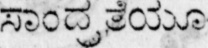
ಸಾಂದ್ರತೆಯೂ
